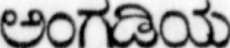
ಅಂಗಡಿಯ
